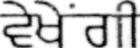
ਵੇਖੇਂਗੀ
